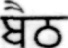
ਬੈਠ
